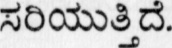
ಸರಿಯುತ್ತಿದೆ.
